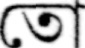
তো
